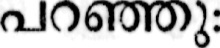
പറഞ്ഞു:
